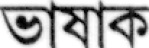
ভাষাক
